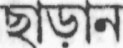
ছাড়ান
